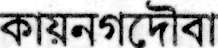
কায়নগদৌবা
